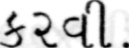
કરવી.
